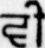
ਵੀ
